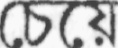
চেয়ে
